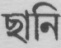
ছানি
